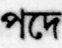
পদে
